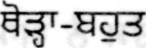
ਥੋੜ੍ਹਾ-ਬਹੁਤ
